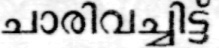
ചാരിവച്ചിട്ട്
